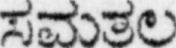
ಸಮತಲ
